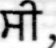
ਸੀ,
